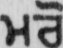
ਮਰੋ
